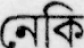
নেকি
